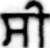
ਸੀ
